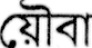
য়ৌবা
